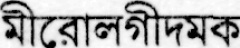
মীরোলগীদমক
